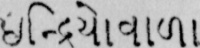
ઈન્દ્રિયોવાળા
